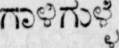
ಗಾಳಿಗುಳ್ಳೆ
